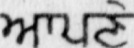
ਆਪਣੇ
